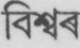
বিশ্বৰ
